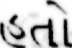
હતો
